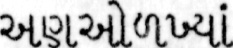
અણઓળખ્યાં
